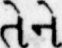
તેને
